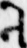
ને
